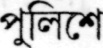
পুলিশে
